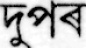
দুপৰ
